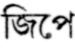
জিপে
